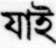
যাই
